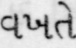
વખતે
